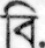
বি.
